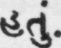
હતું.
